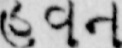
હવન
